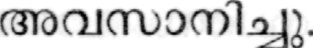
അവസാനിച്ചു.
